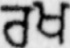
ਰਖ
